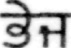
ਭੇਜ
